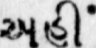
અહીં
